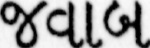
જવાબ
